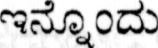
ಇನ್ನೊಂದು
